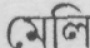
মেলি
